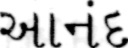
આનંદ
